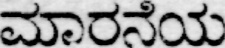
ಮಾರನೆಯ
